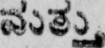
ಮತ್ತು
